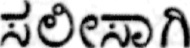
ಸಲೀಸಾಗಿ
